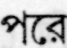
পরে
